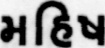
મહિષ
